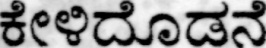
ಕೇಳಿದೊಡನೆ
